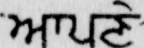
ਆਪਣੇ
